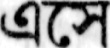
এসে
